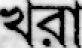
খরা
